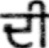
ਦੀ
